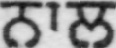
ਨਾਲ
